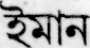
ইমান
